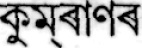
কুম্‌ৰাণৰ
